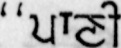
''ਪਾਣੀ
